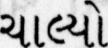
ચાલ્યો
